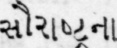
સૌરાષ્ટ્રના
